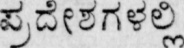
ಪ್ರದೇಶಗಳಲ್ಲಿ
